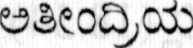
ಅತೀಂದ್ರಿಯ
